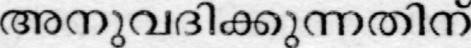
അനുവദിക്കുന്നതിന്
